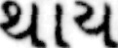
થાય
